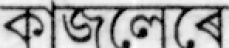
কাজলেৰে
